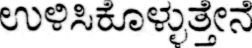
ಉಳಿಸಿಕೊಳ್ಳುತ್ತೇನೆ
